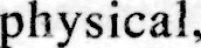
physical,
